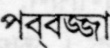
পব্বজ্জা
